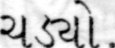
ચડ્યો.
